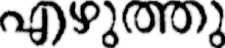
എഴുത്തു
